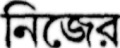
নিজের
